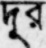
দূর
